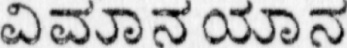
ವಿಮಾನಯಾನ
